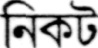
নিকট
